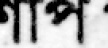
শাপ
